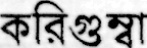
করিগুম্বা
